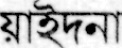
য়াইদনা
